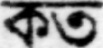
কত
